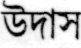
উদাস
